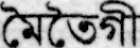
মৈতৈগী
